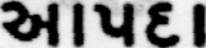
આપદા
